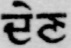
ਦੇਣ
